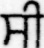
ਸੀ
